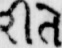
રીતે
